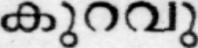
കുറവു
